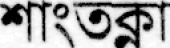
শাংতক্না
